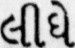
લીધે
